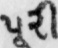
પૂરી
